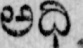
ಅಧಿ
